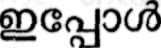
ഇപ്പോള്‍
